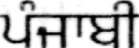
ਪੰਜਾਬੀ
